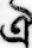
ঐ
